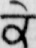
ਕੇ
